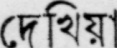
দেখিয়া
